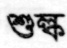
শুল্ক
